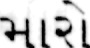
મારો
